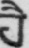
ਹੈ
